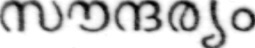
സൌന്ദര്യം
